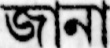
জানা
